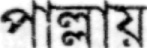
পাল্লায়
